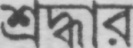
শ্রদ্ধার
